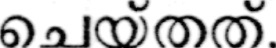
ചെയ്തത്.
